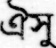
ঐসু
